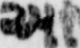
આ
